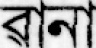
ৱানা
